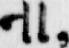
ના,
